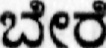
ಬೇರೆ
